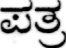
ಪತ್ರ
